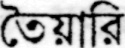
তৈয়ারি
